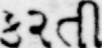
કરતી
